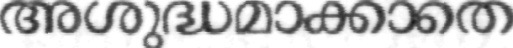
അശുദ്ധമാക്കാതെ
